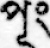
পূং
